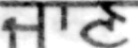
ਜਾਣ
